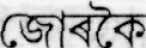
জোৰকৈ
